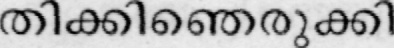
തിക്കിഞെരുക്കി
